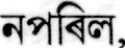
নপৰিল,
